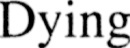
Dying
